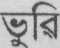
ভুৱি
